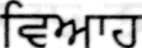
ਵਿਆਹ
